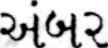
અંબર
